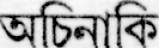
অচিনাকি
